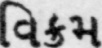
વિક્રમ
